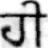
ਹੀ
